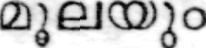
മൂലയും
